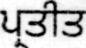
ਪ੍ਰਤੀਤ
